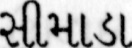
સીમાડા
